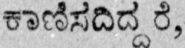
ಕಾಣಿಸದಿದ್ದರೆ,
